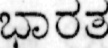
ಭಾರತ
